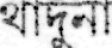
থাদুনা
